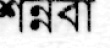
শিন্নবা
